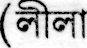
(লীলা
